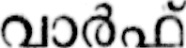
വാര്‍ഫ്
